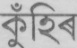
কুঁহিৰ
